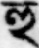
হু
